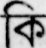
কি
